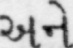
અને
